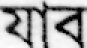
যাব
